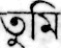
তুমি
